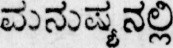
ಮನುಷ್ಯನಲ್ಲಿ
